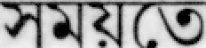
সময়তে
